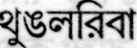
থুঙলরিবা
